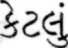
કેટલું
